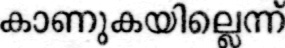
കാണുകയില്ലെന്ന്
